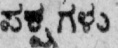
ಪಕ್ಷಗಳು
